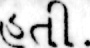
હતી.
